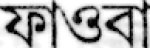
ফাওবা
